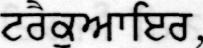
ਟਰੈਕੁਆਇਰ,
